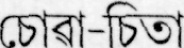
চোৱা-চিতা
